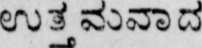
ಉತ್ತಮವಾದ
